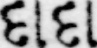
દાદા
